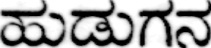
ಹುಡುಗನ
